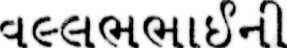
વલ્લભભાઈની
